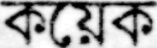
কয়েক
